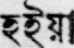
হইয়া
